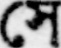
সে
